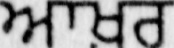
ਆਖ਼ਰ
